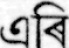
এৰি
